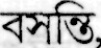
বসন্তি,
